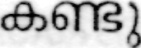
കണ്ടു
